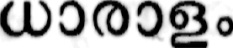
ധാരാളം
